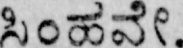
ಸಿಂಹವೇ.
